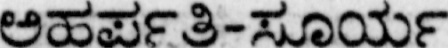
ಅಹರ್ಪತಿ-ಸೂರ್ಯ
